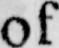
of
